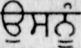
ਉਸਨੂੰ
